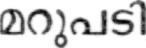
മറുപടി
